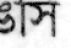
ঙসি
